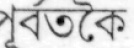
পূর্বতকৈ
